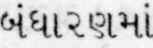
બંધારણમાં
